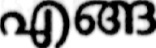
എങ്ങ
